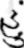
હું
